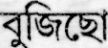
বুজিছো
